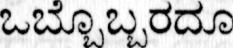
ಒಬ್ಬೊಬ್ಬರದೂ
